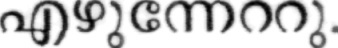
എഴുന്നേററു.
